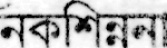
নকশিন্ননা
